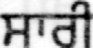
ਸਾਰੀ
